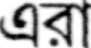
এরা
